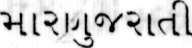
મારાગુજરાતી
